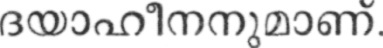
ദയാഹീനനുമാണ്.
